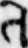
તે
